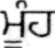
ਮੂੰਹ
